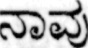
ನಾವು
